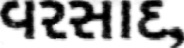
વરસાદ,
